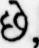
છે,
